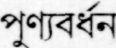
পুণ্যবর্ধন
